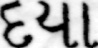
દયા
